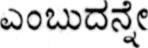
ಎಂಬುದನ್ನೇ
